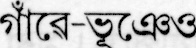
গাঁৱে-ভূঞেও
